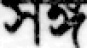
সঙ্গ
